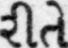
રીતે
